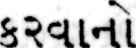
કરવાનો
